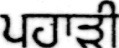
ਪਹਾੜੀ
